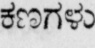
ಕಣಗಳು
